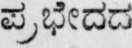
ಪ್ರಭೇದದ
